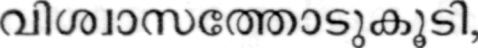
വിശ്വാസത്തോടുകൂടി,
